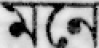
মনে
